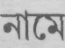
নামে
